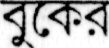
বুকের
